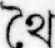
থৈ
